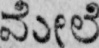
ಮೇಲೆ
